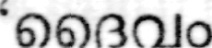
‘ദൈവം
